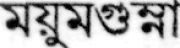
ময়ুমগুম্না
